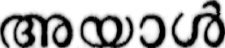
അയാള്‍
